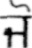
ਜੋ
